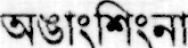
অঙাংশিংনা
